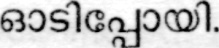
ഓടിപ്പോയി.
